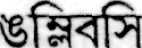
ঙম্লিবসি
